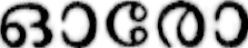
ഓരോ
